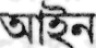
আইন
